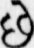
છે
